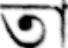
তা
